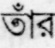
তাঁর
